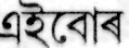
এইবোৰ
